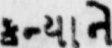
કન્યાને
